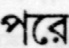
পরে
